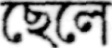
ছেলে
